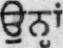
ਉਨ੍ਹਾਂ
